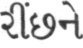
રીંછને
